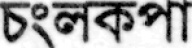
চংলকপা
